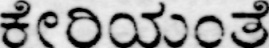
ಕೇರಿಯಂತೆ
